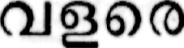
വളരെ
